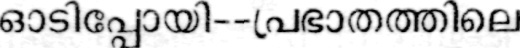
ഓടിപ്പോയി--പ്രഭാതത്തിലെ
